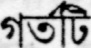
গর্তটি
